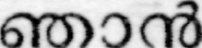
ഞാന്‍
